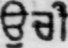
ਉਚੀ
